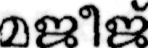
മജീജ്
